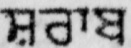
ਸ਼ਰਾਬ
